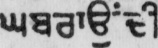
ਘਬਰਾਉਂਦੀ
